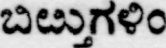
ಬಿೞ್ತುಗಳಿಂ
